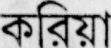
করিয়া
